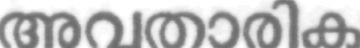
അവതാരിക
